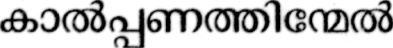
കാല്‍പ്പണത്തിന്മേല്‍
